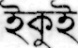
ইকুই
